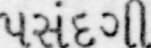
પસંદગી
